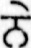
ਨੇ
